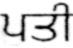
ਪਤੀ
